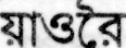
য়াওরৈ
